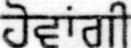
ਹੋਵਾਂਗੀ
